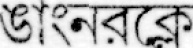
ঙাংনরক্লে
